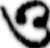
ও
